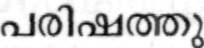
പരിഷത്തു
